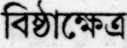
বিষ্ঠাক্ষেত্র
